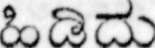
ಹಿಡಿದು
